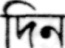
দিন
